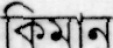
কিমান
